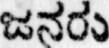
ಜನರು
